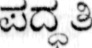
ಪದ್ಧತಿ
